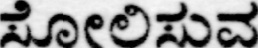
ಸೋಲಿಸುವ
